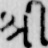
શ્રી
